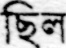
ছিল
